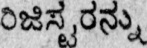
ರಿಜಿಸ್ಟರನ್ನು
